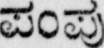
ಪಂಪು
